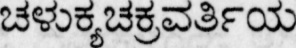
ಚಳುಕ್ಯಚಕ್ರವರ್ತಿಯ
